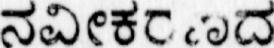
ನವೀಕರಣದ
